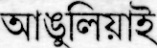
আঙুলিয়াই
